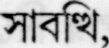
সাবত্থি,
